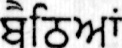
ਬੈਠਿਆਂ
